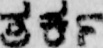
ತರ್ಕ
